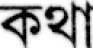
কথা
